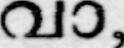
വാ,
